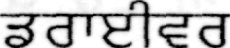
ਡਰਾਈਵਰ
